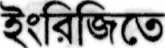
ইংরিজিতে
